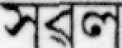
সৱল
